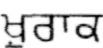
ਖ਼ੁਰਾਕ
